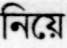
নিয়ে
